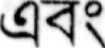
এবং
